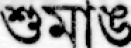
শুমাঙ
